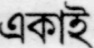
একাই
